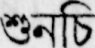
শুনচি
